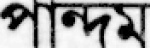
পান্দম
